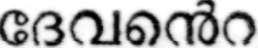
ദേവന്റെ
